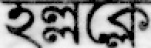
হল্লক্লে
